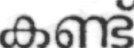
കണ്ട്
